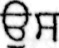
ਉਸ
